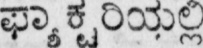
ಫ್ಯಾಕ್ಟರಿಯಲ್ಲಿ
